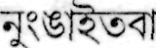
নুংঙাইতবা
